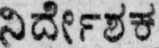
ನಿರ್ದೇಶಕ
